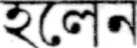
হলেন
